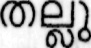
തല്ലു
